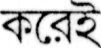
করেই
